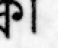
ক্বা
